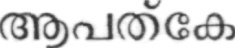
ആപത്കേ
